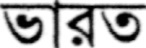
ভারত
